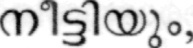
നീട്ടിയും,
